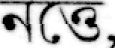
নত্তে,
